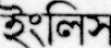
ইংলিস
